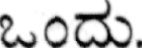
ಒಂದು.
